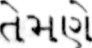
તેમણે
